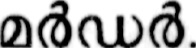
മര്‍ഡര്‍.
